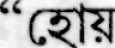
“হোয়
